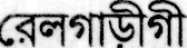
রেলগাড়ীগী
